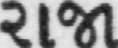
રાજા
